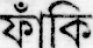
ফাঁকি
